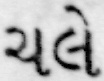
ચલે
